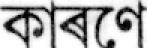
কাৰণে
